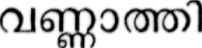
വണ്ണാത്തി
